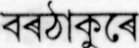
বৰঠাকুৰে
